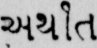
અર્થાત
